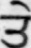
ਤੇ
